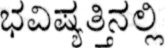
ಭವಿಷ್ಯತ್ತಿನಲ್ಲಿ
